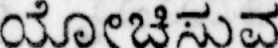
ಯೋಚಿಸುವ
